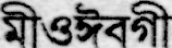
মীওঈবগী
